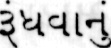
રૂંધવાનું
